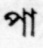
পা
